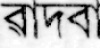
ৱাদবা
